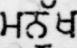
ਮਨੁੱਖ
